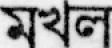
মখল
